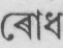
ৰোধ
